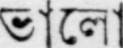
ভালো
